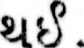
થઈ.
